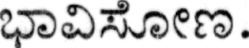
ಭಾವಿಸೋಣ.
